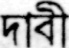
দাবী
